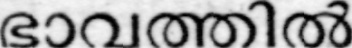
ഭാവത്തില്‍
